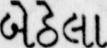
બેઠેલા
